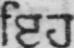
ਇਹ
